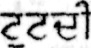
ਟੁਟਦੀ
